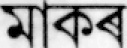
মাকৰ
